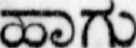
ಹಾಗು
